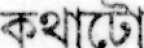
কথাটো
